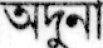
অদুনা
